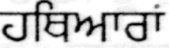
ਹਥਿਆਰਾਂ
